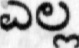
ಎಲ್ಲ
